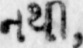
નથી,
